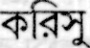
করিসু
